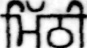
ਮਿੱਠੀ
